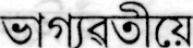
ভাগ্যৱতীয়ে
